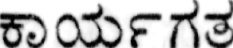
ಕಾರ್ಯಗತ
